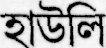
হাউলি
